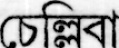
চেল্লিবা
